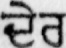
ਦੇਰ
